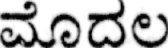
ಮೊದಲ
